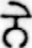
ਨੇ
